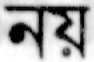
নয়
